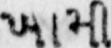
ખામી
